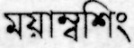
ময়াম্বশিং
